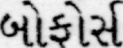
બોફોર્સ
